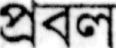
প্রবল
